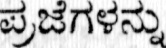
ಪ್ರಜೆಗಳನ್ನು
